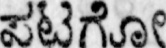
ಪಟಗೋ
